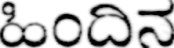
ಹಿಂದಿನ
